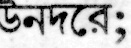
উনদরে;
